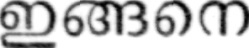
ഇങ്ങനെ
